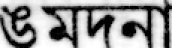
ঙমদনা
